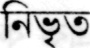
নিভৃত
